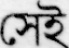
সেই
